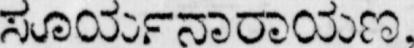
ಸೂರ್ಯನಾರಾಯಣ,
